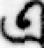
এ
